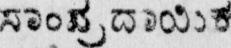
ಸಾಂಪ್ರದಾಯಿಕ
